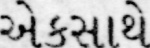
એકસાથે
